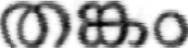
തങ്കം
